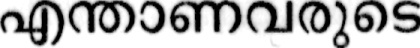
എന്താണവരുടെ
